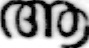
ആ
